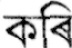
কৰি
